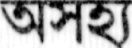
অসহ্য
